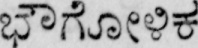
ಭೌಗೋಳಿಕ
